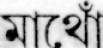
মাথোঁ
